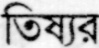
তিষ্যর
